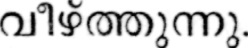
വീഴ്ത്തുന്നു.
